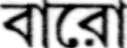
বারো
